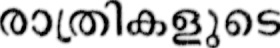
രാത്രികളുടെ
